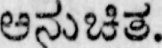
ಅನುಚಿತ.
